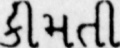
કીમતી
